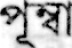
পুম্বা
